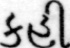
કહી
